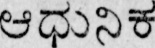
ಆಧುನಿಕ
